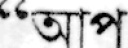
“আপ
